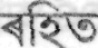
ৰহিত
